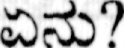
ಏನು?
